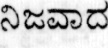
ನಿಜವಾದ
